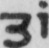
ਤਾਂ
